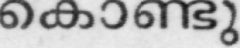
കൊണ്ടു
